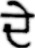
ਦੇ
